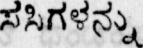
ಸಸಿಗಳನ್ನು
